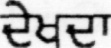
ਦੇਖਦਾ
